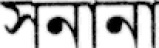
সনানা
